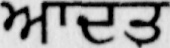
ਆਦਤ
